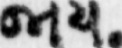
જાય.
